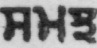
ਸਮਝ
